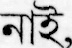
নাই,
